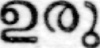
ഉരു
